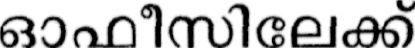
ഓഫീസിലേക്ക്
